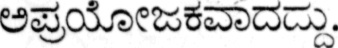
ಅಪ್ರಯೋಜಕವಾದದ್ದು.
